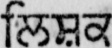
ਲਿਸ਼ਕ
